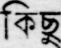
কিছু
